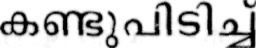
കണ്ടുപിടിച്ച്
